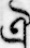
ঐ
